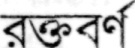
রক্তবর্ণ
